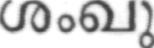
ശംഖു
